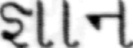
જ્ઞાન
